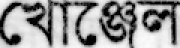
খোঞ্জেল
